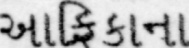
આફ્રિકાના
